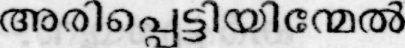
അരിപ്പെട്ടിയിന്മേല്‍
